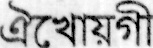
ঐখোয়গী
